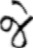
જે
